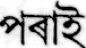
পৰাই
